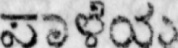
ಪಾಳೆಯ
